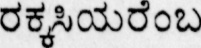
ರಕ್ಕಸಿಯರೆಂಬ
